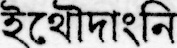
ইথৌদাংনি
